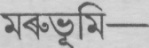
মৰুভূমি-
